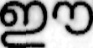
ഈ
